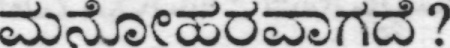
ಮನೋಹರವಾಗದೆ?
